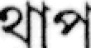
থাপ
